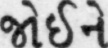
જોઈને
